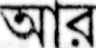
আর
